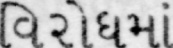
વિરોધમાં
